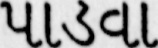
પાડવા
